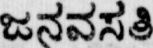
ಜನವಸತಿ
